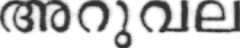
അറുവല
